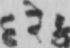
દરેક
